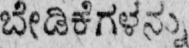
ಬೇಡಿಕೆಗಳನ್ನು
